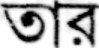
তার
